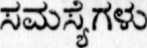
ಸಮಸ್ಯೆಗಳು
